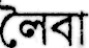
লৈবা
